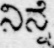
ನಿನ್ನೆ
